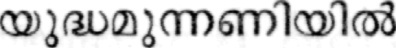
യുദ്ധമുന്നണിയില്‍
